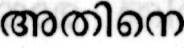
അതിനെ
